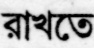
রাখতে
